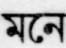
মনে
